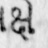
પક્ષે
